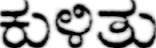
ಕುಳಿತು
